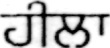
ਹੀਲਾ
